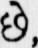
છે,
